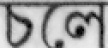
চলে
